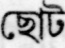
ছোট
